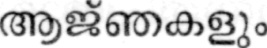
ആജ്ഞകളും
